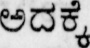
ಅದಕ್ಕೆ
